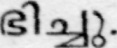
ഭിച്ചു.
